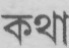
কথা
